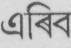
এৰিব
